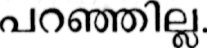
പറഞ്ഞില്ല.
